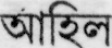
আহিল
